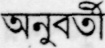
অনুবর্তী
